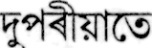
দুপৰীয়াতে
